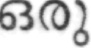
ഒരു
